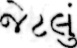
જેટલું
